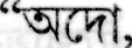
“অদো,
